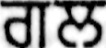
ਗਲ
